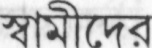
স্বামীদের
